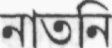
নাতনি
